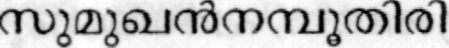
സുമുഖന്‍നമ്പൂതിരി
